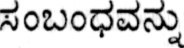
ಸಂಬಂಧವನ್ನು
